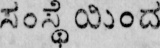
ಸಂಸ್ಥೆಯಿಂದ
